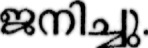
ജനിച്ചു.
